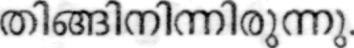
തിങ്ങിനിന്നിരുന്നു.
